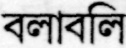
বলাবলি
